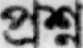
প্রশ্ন
